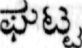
ಘಟ್ಟ
